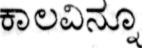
ಕಾಲವಿನ್ನೂ
